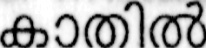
കാതില്‍
